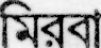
মিরবা
